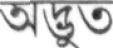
অদ্ভুত
